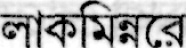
লাকমিন্নরে
